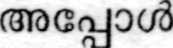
അപ്പോള്‍
